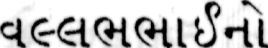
વલ્લભભાઈનો
